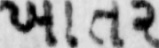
ખાતર
